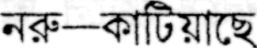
নরু—কাটিয়াছে
